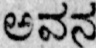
ಅವನ
